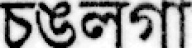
চঙলগা
